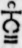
ਨੂੰ
